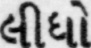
લીધો
